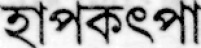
হাপকৎপা
